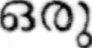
ഒരു
